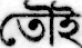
তৌই
